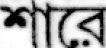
শারে
